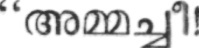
"അമ്മച്ചീ!
